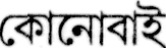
কোনোবাই
